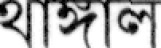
থাঙ্গাল
